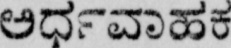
ಅರ್ಧವಾಹಕ
